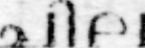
ചില
